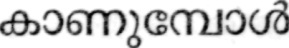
കാണുമ്പോള്‍
